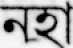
নহা
